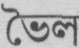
ভৈল
